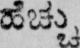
ಹೆಚ್ಚು
